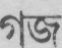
গজ
